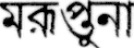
মরূপ্তুনা
